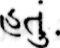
હતું.
